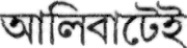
আলিবাটেই
